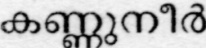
കണ്ണുനീര്‍
